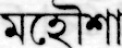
মহৌশা
